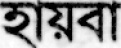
হায়বা
